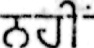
ਨਹੀਂ
